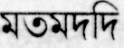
মতমদদি
